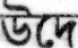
উদে
